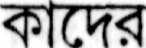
কাদের
